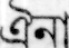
ঐনা
